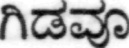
ಗಿಡವೂ
